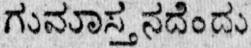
ಗುಮಾಸ್ತನದೆಂದು
